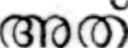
അത്
